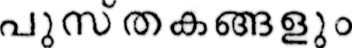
പുസ്തകങ്ങളും
